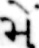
મેં
